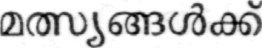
മത്സ്യങ്ങള്‍ക്ക്
